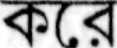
করে
